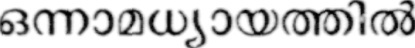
ഒന്നാമധ്യായത്തില്‍
